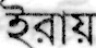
ইরায়
